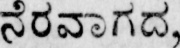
ನೆರವಾಗದ,
